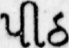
પીઠ
